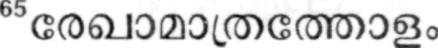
65രേഖാമാത്രത്തോളം
